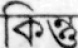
কিন্তু
